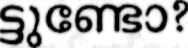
ട്ടുണ്ടോ?
